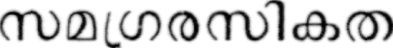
സമഗ്രരസികത
